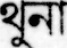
থুনা
